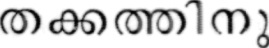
തക്കത്തിനു
